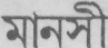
মানসী
